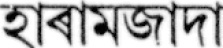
হাৰামজাদা
